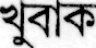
খুবাক
